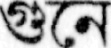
গুনে
